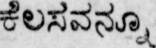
ಕೆಲಸವನ್ನೂ
